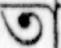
তা
